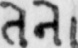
તેનો
